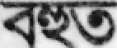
বহুত
